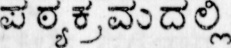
ಪಠ್ಯಕ್ರಮದಲ್ಲಿ
